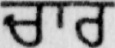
ਚਾਰ
